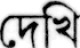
দেখি
